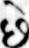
છે
